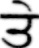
ਤੇ
